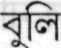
বুলি
